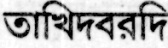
তাখিদবরদি
